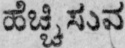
ಹೆಚ್ಚಿಸುವ
